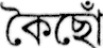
কৈছোঁ
